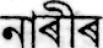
নাৰীৰ
